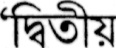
'দ্বিতীয়
